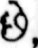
છે,
